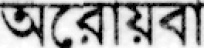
অরোয়বা
